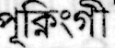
পূক্নিংগী
